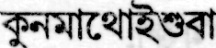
কুনমাথোইশুবা
